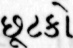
છૂટકો
